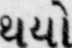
થયો
